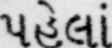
પહેલાં
